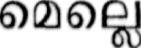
മെല്ലെ
